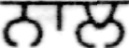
ਨਾਲ
